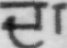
ਦਾ
